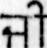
ਜੀ
